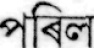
পৰিল
